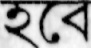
হবে
